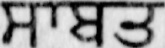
ਸਾਬਤ
